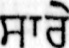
ਸਾਰੇ
